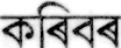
কৰিবৰ
